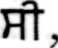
ਸੀ,
